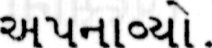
અપનાવ્યો.
